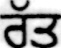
ਰੱਤ
